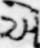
એ
